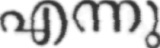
എന്നു
